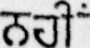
ਨਹੀਂ
